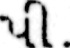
પી.
